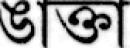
ঙাক্তা
